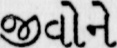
જીવોને
